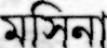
মসিনা
